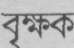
বৃক্ষক
